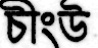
চীংউ
